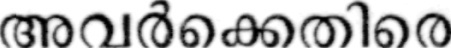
അവര്‍ക്കെതിരെ
